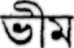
ভীম
